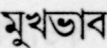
মুখভাব
